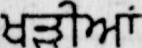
ਖੜੀਆਂ
